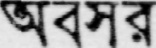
অবসর
